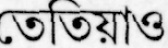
তেতিয়াও
